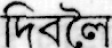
দিবলৈ
